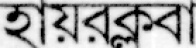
হায়রক্লবা
